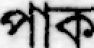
পাক
